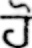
ਹੋ
